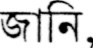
জানি,
